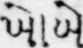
ખોબે
